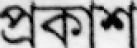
প্রকাশ
